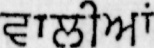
ਵਾਲੀਆਂ
